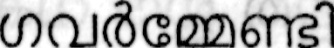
ഗവര്‍മ്മേണ്ടി
